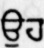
ਉਹ
